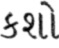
કશો
